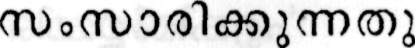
സംസാരിക്കുന്നതു
